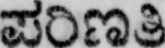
ಪರಿಣತಿ
